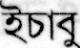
ইচাবু
